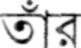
তাঁর
